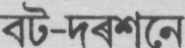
বট-দৰশনে
